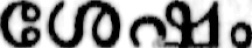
ശേഷം
